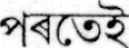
পৰতেই
